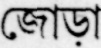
জোড়া
